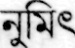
নুমিৎ
